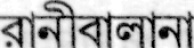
রানীবালানা
